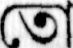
তো
